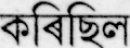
কৰিছিল
